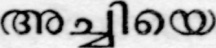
അച്ചിയെ
